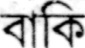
বাকি
